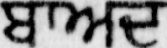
ਬਾਅਦ
